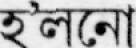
হ'লনো
